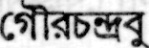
গৌরচন্দ্রবু
